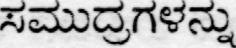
ಸಮುದ್ರಗಳನ್ನು
